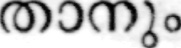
താനും
